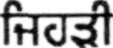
ਜਿਹੜੀ
